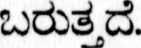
ಬರುತ್ತದೆ.
